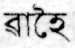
ৱাহৈ
